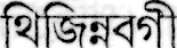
থিজিন্নবগী
